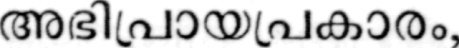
അഭിപ്രായപ്രകാരം,
